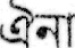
ঐনা
